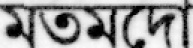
মতমদো
